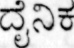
ದೈನಿಕ
